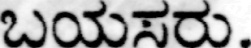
ಬಯಸರು.
